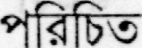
পরিচিত
